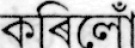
কৰিলোঁ
